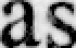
as
